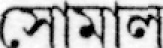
সোমাল
